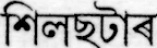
শিলছটাৰ
